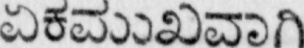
ಏಕಮುಖವಾಗಿ
